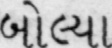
બોલ્યા
